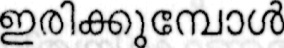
ഇരിക്കുമ്പോള്‍
